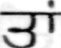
ਤਾਂ
